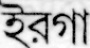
ইরগা
